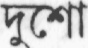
দুশো
